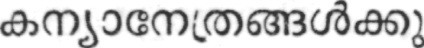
കന്യാനേത്രങ്ങള്‍ക്കു
